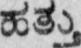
ಹತ್ತು
